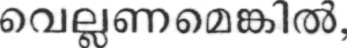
വെല്ലണമെങ്കില്‍,
